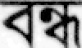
বন্ধ
